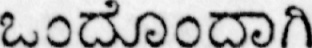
ಒಂದೊಂದಾಗಿ
